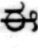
ಈ
